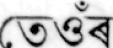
তেওঁৰ
